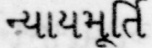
ન્યાયમૂર્તિ
